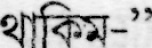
থাকিম-"
